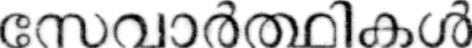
സേവാര്‍ത്ഥികള്‍
